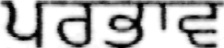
ਪਰਭਾਵ
